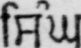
ਸਿੰਘ
